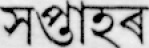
সপ্তাহৰ
